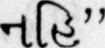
નહિ"
